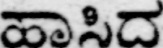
ಹಾಸಿದ
